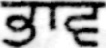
ਭਾਵ
